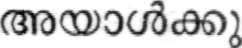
അയാള്‍ക്കു
